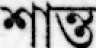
শান্ত
